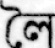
লৈ
